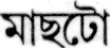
মাছটো
